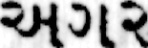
અગર
